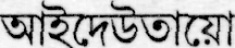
আইদেউতায়ো
